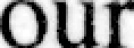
our
